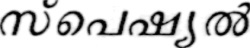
സ്പെഷ്യല്‍
